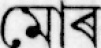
মোৰ
